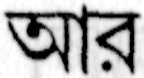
আর
